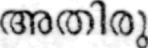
അതിരു
